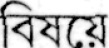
বিষয়ে
